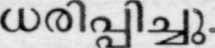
ധരിപ്പിച്ചു.
